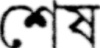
শেষ
